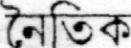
নৈতিক
